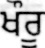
ਖੌਰੂ
